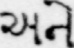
અને
